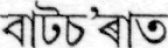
বাটচ'ৰাত
